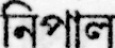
নিপাল
